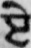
ਏ
